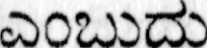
ಎಂಬುದು
